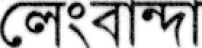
লেংবান্দা
